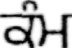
ਕੰਮ
